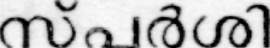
സ്പര്‍ശി
